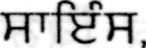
ਸਾਇੰਸ,
